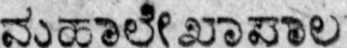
ಮಹಾಲೇಖಾಪಾಲ
